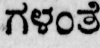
ಗಳಂತೆ
